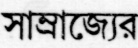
সাম্রাজ্যের
